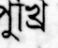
পুখ্রি
